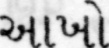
આખો
